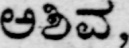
ಅಶಿವ,
